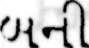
બની
